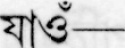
যাওঁ-
